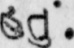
હતું.
